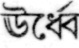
ঊর্ধ্বে
